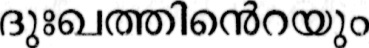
ദുഃഖത്തിന്റെയും
